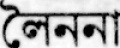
লৈননা
